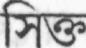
সিক্ত
